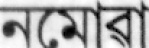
নমোৱা
